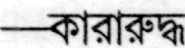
–কারারুদ্ধ
